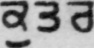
ਕੁਤਰ
